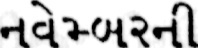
નવેમ્બરની
